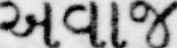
અવાજ
